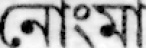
নোংমা
